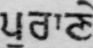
ਪੁਰਾਣੇ
